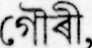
গৌৰী,
